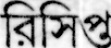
রিসিপ্ত
